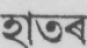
হাতৰ
